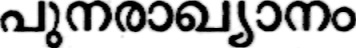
പുനരാഖ്യാനം
